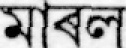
মাৰল
